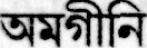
অমগীনি
